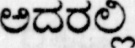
ಅದರಲ್ಲಿ
